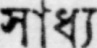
সাধ্য
